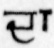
ਦਾ
